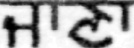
ਜਾਣਾ
